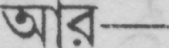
আর-
